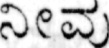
ನೀವು
